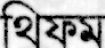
থিফম
